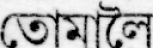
তোমালৈ
